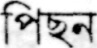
পিছন
